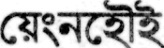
য়েংনহৌই
